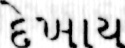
દેખાય
